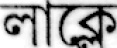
লাক্লে
